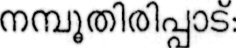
നമ്പൂതിരിപ്പാട്:
